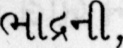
ભાદ્રની,
